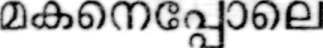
മകനെപ്പോലെ
